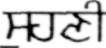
ਸੁਹਣੀ
